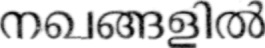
നഖങ്ങളില്‍
